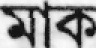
মাক
